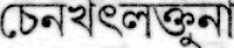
চেনখৎলক্তুনা
